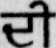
ਦੀ
